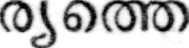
ര്യത്തെ
